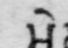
ਮੇਨ
